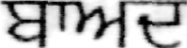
ਬਾਅਦ
